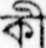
কী
